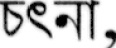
চৎনা,
